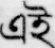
এই
